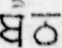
ਬੈਠ
